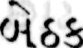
બેઠક
